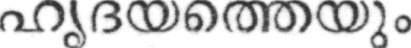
ഹൃദയത്തെയും
